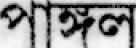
পাঙ্গল
